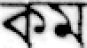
কম
